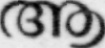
ആ
